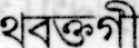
থবক্তগী
